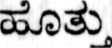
ಹೊತ್ತು
